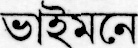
ভাইমনে
